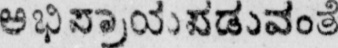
ಅಭಿಪ್ರಾಯಪಡುವಂತೆ
